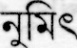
নুমিৎ
